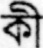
কী
